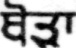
ਥੋੜਾ
